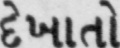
દેખાતો
